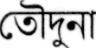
তৌদুনা
